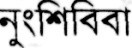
নুংশিবিবা
